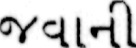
જવાની
